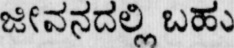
ಜೀವನದಲ್ಲಿಬಹು
